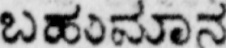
ಬಹುಮಾನ
